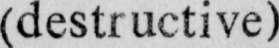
(destructive)
